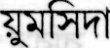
য়ুমসিদা
